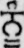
ਨੂੰ
